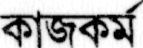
কাজকর্ম
